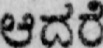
ಆದರೆ
